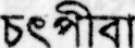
চৎপীবা
